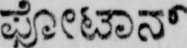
ಫೋಟಾನ್
